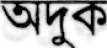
অদুক
